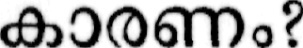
കാരണം?
